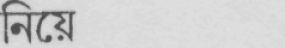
নিয়ে
